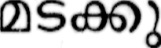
മടക്കു
